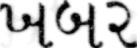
ખબર
